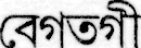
বেগতগী
